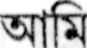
আমি
